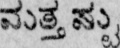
ಮತ್ತಷ್ಟು
